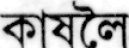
কাষলৈ
